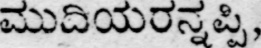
ಮುದಿಯರನ್ನಪ್ಪಿ,
